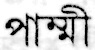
পাম্মী
